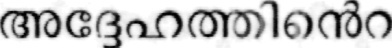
അദ്ദേഹത്തിന്റെ
